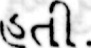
હતી.
